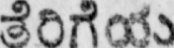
ತೆರಿಗೆಯ
